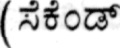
(ಸೆಕೆಂಡ್
